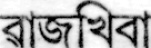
ৱাজখিবা
